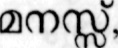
മനസ്സ്,
